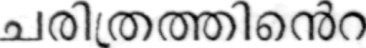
ചരിത്രത്തിന്റെ
